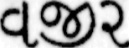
વજીર
